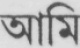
আমি
